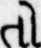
તો
